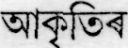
আকৃতিৰ
